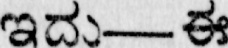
ಇದು-ಈ
